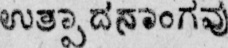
ಉತ್ಪಾದನಾಂಗವು
